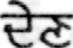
ਦੇਣ
